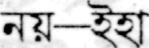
নয়—ইহা
